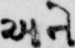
અને
